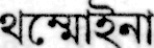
থম্মোইনা
